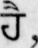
ਹੈ,
